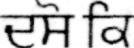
ਦਸੋਕਿ
